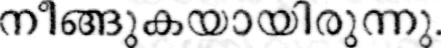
നീങ്ങുകയായിരുന്നു.
